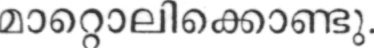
മാറ്റൊലിക്കൊണ്ടു.
